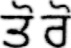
ਤੋਰੋ
